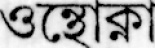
ওন্থোক্না
